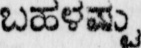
ಬಹಳಷ್ಟು
